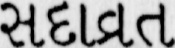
સદાવ્રત
